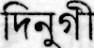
দিনুগী
